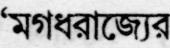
‘মগধরাজ্যের
